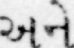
અને
